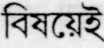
বিষয়েই
